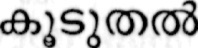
കൂടുതല്‍
